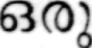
ഒരു
